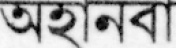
অহানবা
